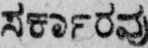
ಸರ್ಕಾರವು
